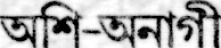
অশি-অনাগী
